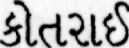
કોતરાઈ
